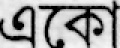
একো
